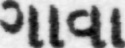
ગાવા
